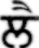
ਲੈ
